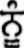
ਨੂੰ
